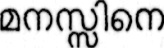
മനസ്സിനെ
